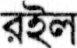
রইল
